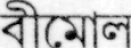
বীমোল
